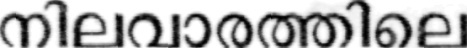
നിലവാരത്തിലെ
